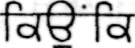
ਕਿਉਂਕਿ
